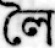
লৈ
